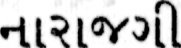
નારાજગી
